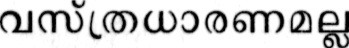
വസ്ത്രധാരണമല്ല
